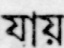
যায়
